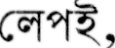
লেপই,
